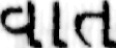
વાત
